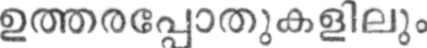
ഉത്തരപ്പോതുകളിലും
